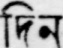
দিন
